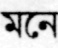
মনে
